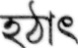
হঠাৎ
